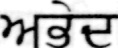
ਅਭੇਦ
